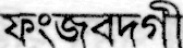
ফংজবদগী
